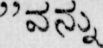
ವನ್ನು
